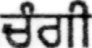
ਚੰਗੀ
